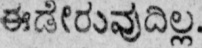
ಈಡೇರುವುದಿಲ್ಲ.
